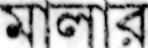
মালার
